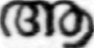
ആ
